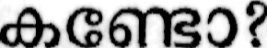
കണ്ടോ?
